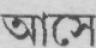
আসে
